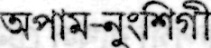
অপাম-নুংশিগী
